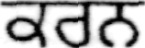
ਕਰਨ
